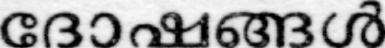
ദോഷങ്ങള്‍
